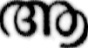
ആ
